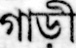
গাড়ী
